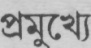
প্ৰমুখ্যে
